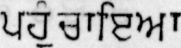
ਪਹੁੰਚਾਇਆ
